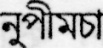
নুপীমচা
